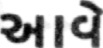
આવે
